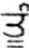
ਤੂੰ
